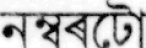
নম্বৰটো
